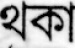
থকা
